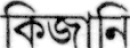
কিজানি
